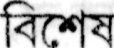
বিশেষ
